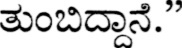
ತುಂಬಿದ್ದಾನೆ."
